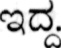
ಇದ್ದ.
